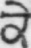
ਕੇ
